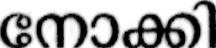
നോക്കി
